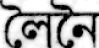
লৈনৈ
